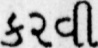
કરવી
